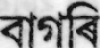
বাগৰি
